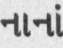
નાનાં
